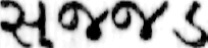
સજ્જડ
